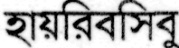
হায়রিবসিবু
